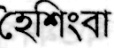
হৈশিংবা
